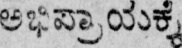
ಅಭಿಪ್ರಾಯಕ್ಕೆ
